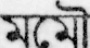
মমৌ
